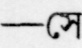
–সে
